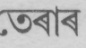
তেৰাৰ
